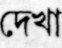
দেখা
